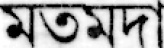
মতমদা
